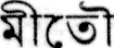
মীতৌ
